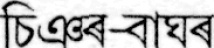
চিঞৰ-বাঘৰ
